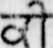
ਕੀ
